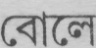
বোলে
